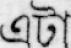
এটা
